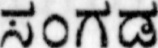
ಸಂಗಡ
